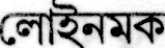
লোইনমক
